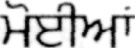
ਮੋਈਆਂ
